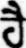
ਹੈ
